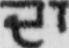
ਦਾ
